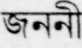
জননী
